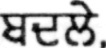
ਬਦਲੇ,
